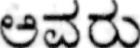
ಅವರು
